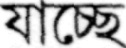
যাচ্ছে
